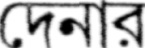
দেনার
